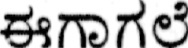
ಈಗಾಗಲೆ
